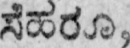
ನೆಹರೂ,
